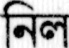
নিল
